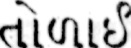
તોળાઈ
